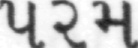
પરમ
